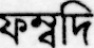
ফম্বদি
